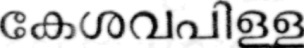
കേശവപിള്ള
